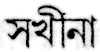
সখীনা
